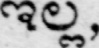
ಇಲ್ಲ,
